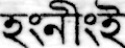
হংনীংই
